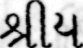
શ્રીય
